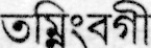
তম্নিংবগী
